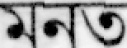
মনত
